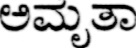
ಅಮೃತಾ
